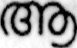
ആ
